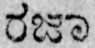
ರಜಾ
